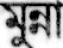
মুন্না
